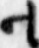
ન
